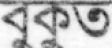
বুকুত
